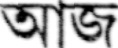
আজ
